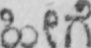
ಹೀಗೆ
